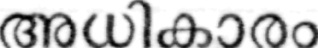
അധികാരം
